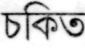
চকিত
